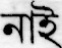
নাই
